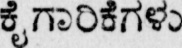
ಕೈಗಾರಿಕೆಗಳು
